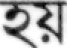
হয়
